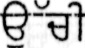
ਉੱਚੀ
